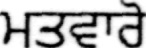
ਮਤਵਾਰੋ
